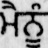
ਮੈਨੂੰ
